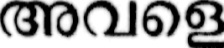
അവളെ
